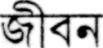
জীবন
